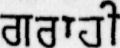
ਗਰਾਹੀ
